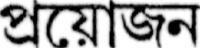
প্রয়োজন
